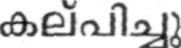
കല്പിച്ചു
